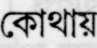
কোথায়
